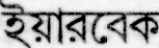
ইয়ারবেক
